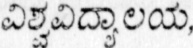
ವಿಶ್ವವಿದ್ಯಾಲಯ,
